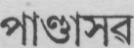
পাণ্ডাসৱ
